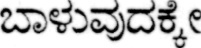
ಬಾಳುವುದಕ್ಕೇ
